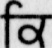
ਕਿ
